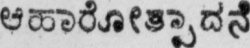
ಆಹಾರೋತ್ಪಾದನೆ
